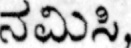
ನಮಿಸಿ,
